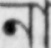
না
